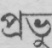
প্ৰভু
